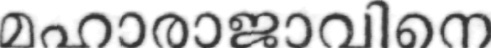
മഹാരാജാവിനെ
